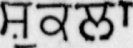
ਸ਼ੁਕਲਾ
